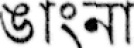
ঙাংনা
